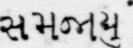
સમજાયું
